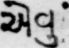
એવું
